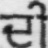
ਦੀ
